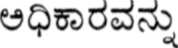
ಅಧಿಕಾರವನ್ನು
